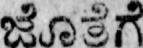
ಜೊತೆಗೆ
